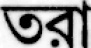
তরা
